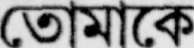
তোমাকে
